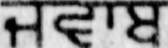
ਜਵਾਬ
